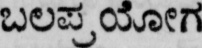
ಬಲಪ್ರಯೋಗ
